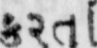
કરતાં
